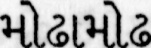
મોઢામોઢ
